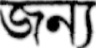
জন্য
